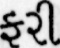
ફરી
